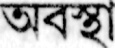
অবস্থা
